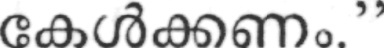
കേള്‍ക്കണം."
